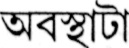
অবস্থাটা
